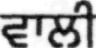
ਵਾਲੀ
